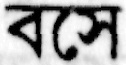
বসে
